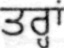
ਤਰ੍ਹਾਂ
